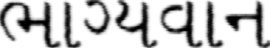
ભાગ્યવાન
